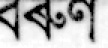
বৰুণ
